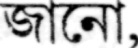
জানো,
